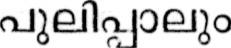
പുലിപ്പാലും
